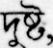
দুষ্ট,
